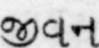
જીવન
